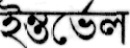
ইন্তর্ভেল
